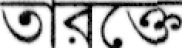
তারক্তে
